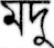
মদু
